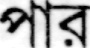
পার
